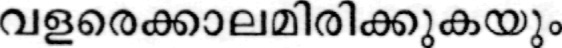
വളരെക്കാലമിരിക്കുകയും
